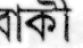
বাকী
